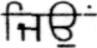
ਜਿਉਂ
